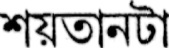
শয়তানটা
